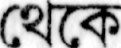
থেকে
